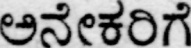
ಅನೇಕರಿಗೆ
